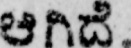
ಆಗಿದೆ.
